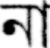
না
